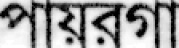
পায়রগা
